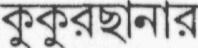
কুকুরছানার
